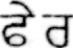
ਫੇਰ
